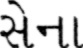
સેના
